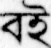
বই
